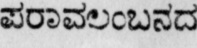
ಪರಾವಲಂಬನದ
